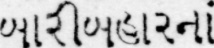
બારીબહારનાં
